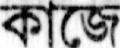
কাজে
